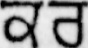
ਕਰ
